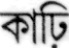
কাঢ়ি
